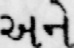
અને
